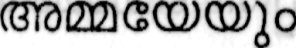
അമ്മയേയും
